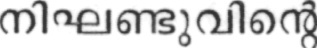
നിഘണ്ടുവിന്റെ
